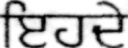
ਇਹਦੇ
